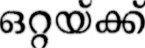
ഒറ്റയ്ക്ക്
